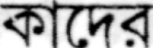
কাদের
